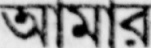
আমার
